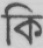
কি
